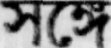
সঙ্গে
